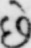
છે
